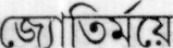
জ্যোতির্ময়ে
